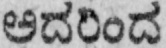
ಆದರಿಂದL
